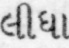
લીધા
